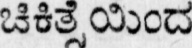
ಚಿಕಿತ್ಸೆಯಿಂದ
